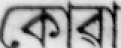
কোৱা
